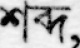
শব্দ,
